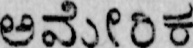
ಅಮೇರಿಕ
